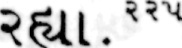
રહ્યા.૨૨૫
